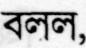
বলল,
